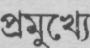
প্ৰমুখ্যে
